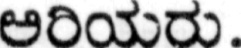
ಅರಿಯರು.
